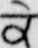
ਕੇ
